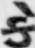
કે
